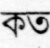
কত
